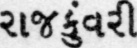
રાજકુંવરી
